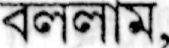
বললাম,
